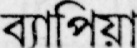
ব্যাপিয়া
